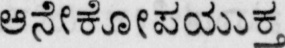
ಅನೇಕೋಪಯುಕ್ತ
